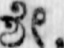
ಶೇ.
